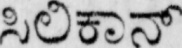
ಸಿಲಿಕಾನ್
